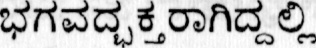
ಭಗವದ್ಭಕ್ತರಾಗಿದ್ದಲ್ಲಿ
